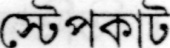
স্টেপকাট
